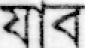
যাব
